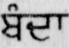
ਬੰਦਾ
